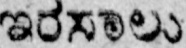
ಇರಸಾಲು
